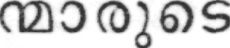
ന്മാരുടെ
